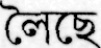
লৈছে
